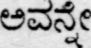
ಅವನ್ನೇ
